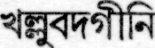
খল্লুবদগীনি
